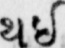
થઈ
